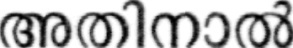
അതിനാല്‍
